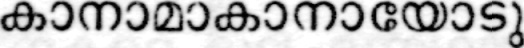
കാനാമാകാനായോടു
